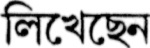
লিখেছেন
